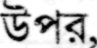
উপর,
